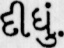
દીધું.
